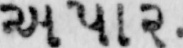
અપાર.
